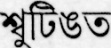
শ্বুটিঙত
